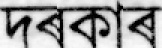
দৰকাৰ
